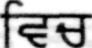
ਵਿਚ
